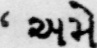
'અમે
